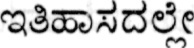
ಇತಿಹಾಸದಲ್ಲೇ
